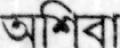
অশিবা
